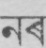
নৰ
